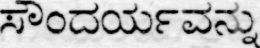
ಸೌಂದರ್ಯವನ್ನು
